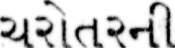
ચરોતરની
